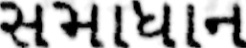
સમાધાન
